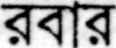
রবার
